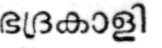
ഭദ്രകാളി
